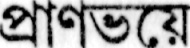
প্রাণভয়ে
